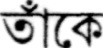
তাঁকে
